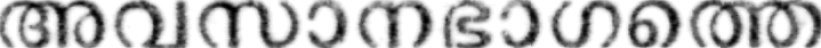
അവസാനഭാഗത്തെ
